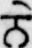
ਨੇ
